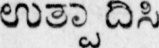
ಉತ್ಪಾದಿಸಿ
